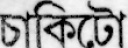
চাকিটো
